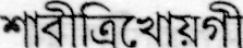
শাবীত্রিখোয়গী
